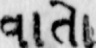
વાતો
